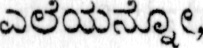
ಎಲೆಯನ್ನೋ,
